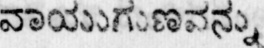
ವಾಯುಗುಣವನ್ನು
